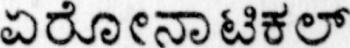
ಏರೋನಾಟಿಕಲ್
